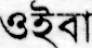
ওইবা
